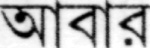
আবার
